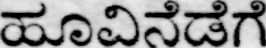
ಹೂವಿನೆಡೆಗೆ
